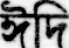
ঈদি
